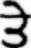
ਤੇ
